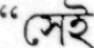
"সেই
